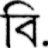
বি.
